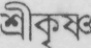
শ্ৰীকৃষ্ণ
